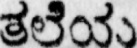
ತಲೆಯ
